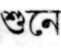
শুনে
